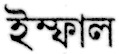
ইম্ফাল
